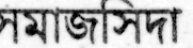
সমাজসিদা
